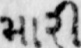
મારી
